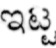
ಇಟ್ಟ
